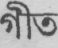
গীত
